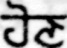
ਹੋਣ
